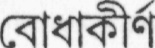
বোধাকীর্ণ
